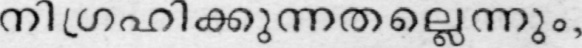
നിഗ്രഹിക്കുന്നതല്ലെന്നും,
